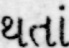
થતાં
